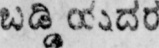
ಬಡ್ಡಿಯದರ
